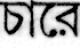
চারে
